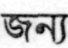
জন্য
